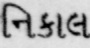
નિકાલ
